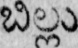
ಬಿಲ್ಲು
